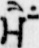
ਮੈਂ
